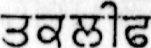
ਤਕਲੀਫ
